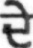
ਦੇ
